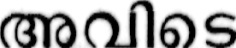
അവിടെ
